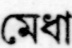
মেধা
